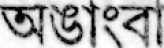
অঙাংবা
